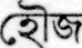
হৌজ
